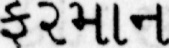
ફરમાન
